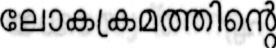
ലോകക്രമത്തിന്റെ
